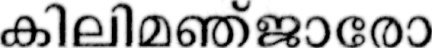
കിലിമഞ്ജാരോ
